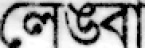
লেঙবা
